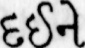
દઈને
